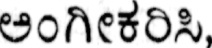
ಅಂಗೀಕರಿಸಿ,
